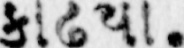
કાઢ્યા
